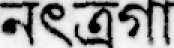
নৎত্রগা
